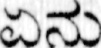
ಏನು
